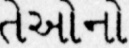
તેઓનો
